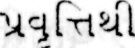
પ્રવૃત્તિથી
